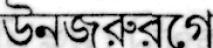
উনজরুরগে
